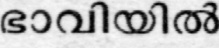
ഭാവിയില്‍
